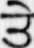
ਤੇ
